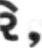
રે,
